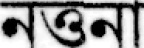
নত্তনা
